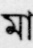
মা
